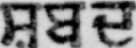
ਸ਼ਬਦ
